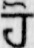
ਹੋ
